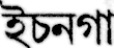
ইচনগা
